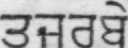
ਤਜਰਬੇ
